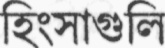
হিংসাগুলি
